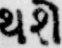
થશે
